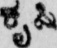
ಕೃಷಿ
